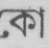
কো
